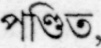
পণ্ডিত,
